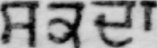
ਸਕਦਾ
